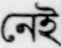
নেই
